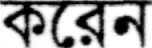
করেন
